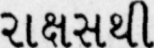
રાક્ષસથી
